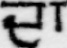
ਦਾ
